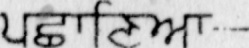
ਪਛਾਣਿਆ-
